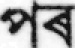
পৰ
